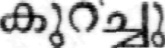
കുറച്ചു
